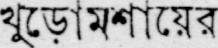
খুড়োমশায়ের
